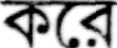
করে
